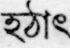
হঠাত্
